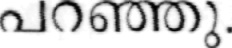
പറഞ്ഞു.
